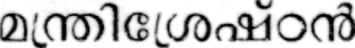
മന്ത്രിശ്രേഷ്ഠന്‍
